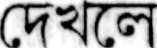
দেখলে
